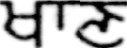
ਖਾਣ
